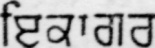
ਇਕਾਗਰ
